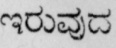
ಇರುವುದ
